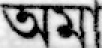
অমা
